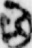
છે
